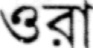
ওরা
